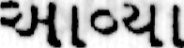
આવ્યા
